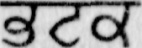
ਭਟਕ
